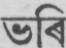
ভৰি
